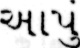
આપું
